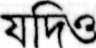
যদিও
